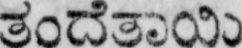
ತಂದೆತಾಯಿ
